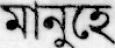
মানুহে
